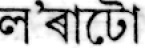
ল'ৰাটো
